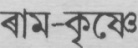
ৰাম-কৃষ্ণে
